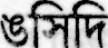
ঙসিদি
